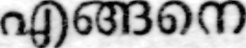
എങ്ങനെ
